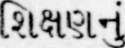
શિક્ષણનું
